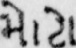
મોટો
